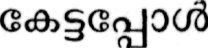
കേട്ടപ്പോള്‍
